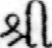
શ્રી
